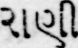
રાણી
